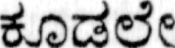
ಕೂಡಲೇ
